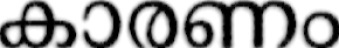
കാരണം
